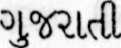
ગુજરાતી
